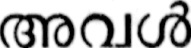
അവള്‍
